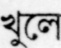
খুলে
